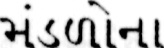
મંડળોના
